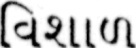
વિશાળ
